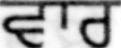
ਵਾਰ
